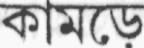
কামড়ে
